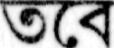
তবে
